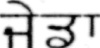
ਜੇਡਾ
